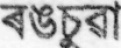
ৰঙচুৱা
